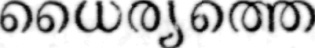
ധൈര്യത്തെ
